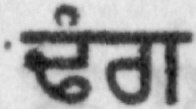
ਢੰਗ
